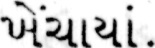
ખેંચાયાં.
